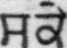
ਸਕੇ
